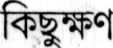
কিছুক্ষণ
